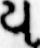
ય
